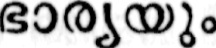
ഭാര്യയും
